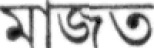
মাজত
